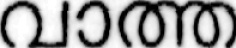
വാത്ത
